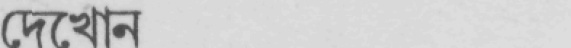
দেখোন
